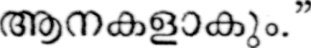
ആനകളാകും.”
